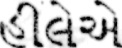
હીલેએ
